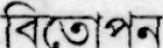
বিতোপন
